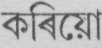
কৰিয়ো
